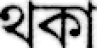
থকা
